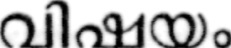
വിഷയം
